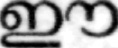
ഈ
